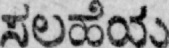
ಸಲಹೆಯ
